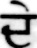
ਦੇ
